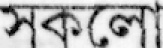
সকলো
